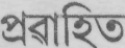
প্ৰৱাহিত
